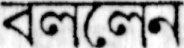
বললেন
